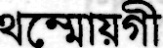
থম্মোয়গী
